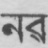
নৱ
